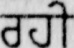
ਰਹੀ
